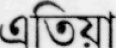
এতিয়া
